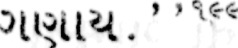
ગણાય."૧૯૯
